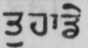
ਤੁਹਾਡੇ
